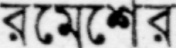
রমেশের
